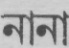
নানা
